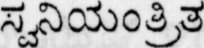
ಸ್ವನಿಯಂತ್ರಿತ
